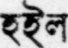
হইল
